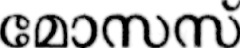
മോസസ്
